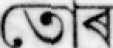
তোৰ
